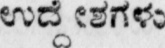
ಉದ್ದೇಶಗಳು
